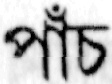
পাঁচ
